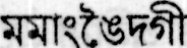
মমাংঙৈদগী
